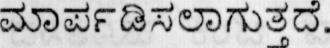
ಮಾರ್ಪಡಿಸಲಾಗುತ್ತದೆ.
